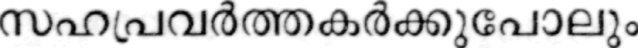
സഹപ്രവര്‍ത്തകര്‍ക്കുപോലും
